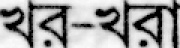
খর-খরা
